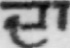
ਦਾ
